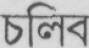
চলিব
